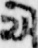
એ
